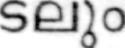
ടലും
